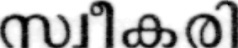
സ്വീകരി
